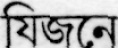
যিজনে
